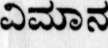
ವಿಮಾನ
